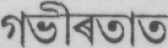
গভীৰতাত
